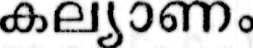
കല്യാണം
